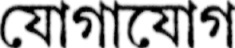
যোগাযোগ
